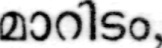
മാറിടം,
